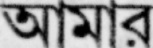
আমার
